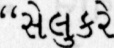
"સેલુકરે
